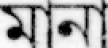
মানা
